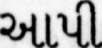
આપી
